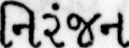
નિરંજન
